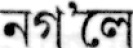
নগ'লে
